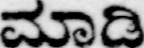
ಮಾಡಿ
